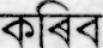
কৰিব
